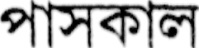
পাসকাল
